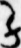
કે
